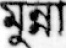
মুন্না
